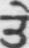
ਤੇ
